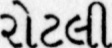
રોટલી
